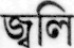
জ্বলি
